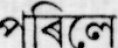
পৰিলে
